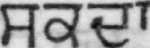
ਸਕਦਾ
